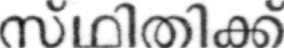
സ്ഥിതിക്ക്
